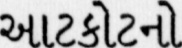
આટકોટનો
